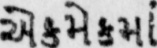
એકમેકમાં
